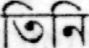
তিনি
